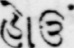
હોઉં
